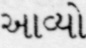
આવ્યો
